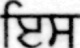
ਇਸ
